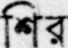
শির
